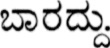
ಬಾರದ್ದು.
